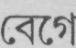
বেগে
